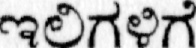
ಇಲಿಗಳಿಗೆ
